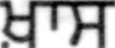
ਖ਼ਾਸ
